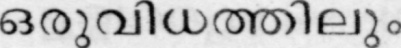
ഒരുവിധത്തിലും
